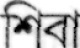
শিবা
